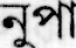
নুপা
